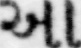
આ
